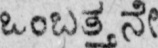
ಒಂಬತ್ತನೇ
